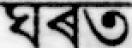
ঘৰত
